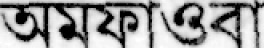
অমফাওবা
